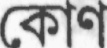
কোণ
